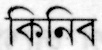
কিনিব
